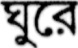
ঘুরে
